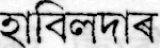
হাবিলদাৰ
